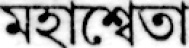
মহাশ্বেতা
